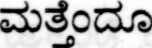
ಮತ್ತೆಂದೂ
